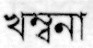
খম্বনা
